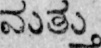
ಮತ್ತು
